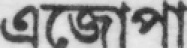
এজোপা
